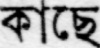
কাছে
